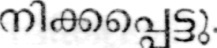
നിക്കപ്പെട്ടു.
